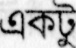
একটু
